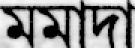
মমাদা
